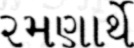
રમણાર્થે
